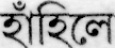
হাঁহিলে
